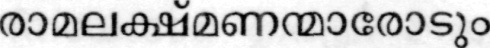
രാമലക്ഷ്മണന്മാരോടും
